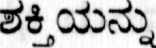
ಶಕ್ತಿಯನ್ನು
